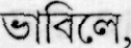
ভাবিলে,
